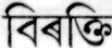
বিৰক্তি
